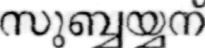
സുബ്ബയ്യന്
